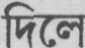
দিলে
